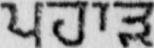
ਪਹਾੜ
